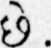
છે.
